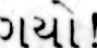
ગયો!
